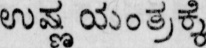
ಉಷ್ಣಯಂತ್ರಕ್ಕೆ
